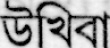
উখিবা
